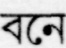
বনে
